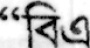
"বিএ
